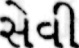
સેવી
